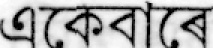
একেবাৰে
